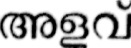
അളവ്
